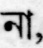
না,
